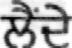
ਲੈਂਦੇ
